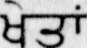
ਖੇਤਾਂ
